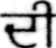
ਦੀ
